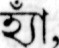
হ্যাঁ,
